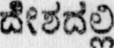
ದೇಶದಲ್ಲಿ
